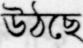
উঠছে
